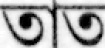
তাত
